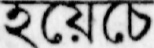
হয়েচে
